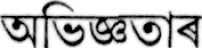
অভিজ্ঞতাৰ
